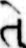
તે
